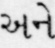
અને
